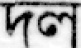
দল
